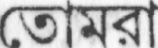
তোমরা
